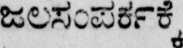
ಜಲಸಂಪರ್ಕಕ್ಕೆ
